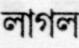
লাগল
